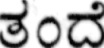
ತಂದೆ
